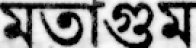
মতাগুম
